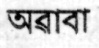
অৱাবা
